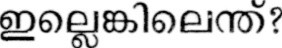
ഇല്ലെങ്കിലെന്ത്?
